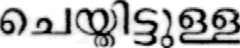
ചെയ്തിട്ടുള്ള
